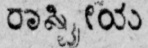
ರಾಷ್ಟ್ರೀಯ
